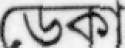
ডেকা
